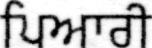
ਪਿਆਰੀ
